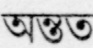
অন্তত
